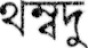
থম্বদু
